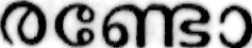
രണ്ടോ
